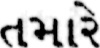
તમારે
